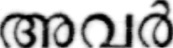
അവര്‍
